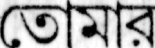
তোমার
